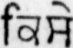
ਕਿਸੇ
